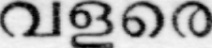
വളരെ
